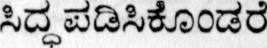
ಸಿದ್ಧಪಡಿಸಿಕೊಂಡರೆ
